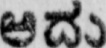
ಅದು
